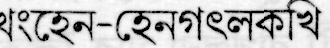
খংহেন-হেনগৎলকখি
